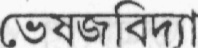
ভেষজবিদ্যা
